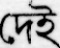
দেই
